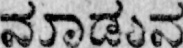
ಮಾಡುವ
